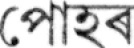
পোহৰ
